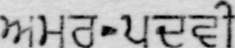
ਅਮਰ-ਪਦਵੀ
